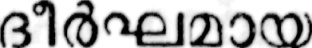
ദീര്‍ഘമായ
